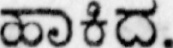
ಹಾಕಿದ.
